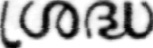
ശ്രദ്ധ
